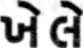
ખેલે
